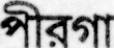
পীরগা
